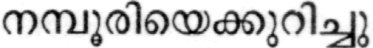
നമ്പൂരിയെക്കുറിച്ചു
